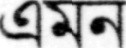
এমন
